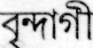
বৃন্দাগী
